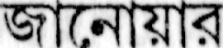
জানোয়ার
